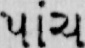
પાંચ
